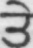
ਤੇ
